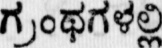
ಗ್ರಂಥಗಳಲ್ಲಿ
